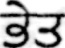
ਭੇਤ
